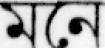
মনে
